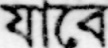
যাবে
